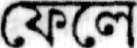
ফেলে
